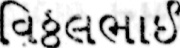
વિઠ્ઠલભાઈ
